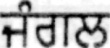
ਜੰਗਲ
